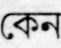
কেন
